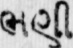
ભણી
